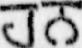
ਹਨ
